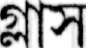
গ্লাস
